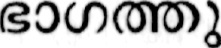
ഭാഗത്തു
